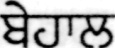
ਬੇਹਾਲ
